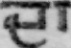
ਦਾ
